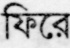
ফিরে
